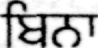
ਬਿਨਾ
